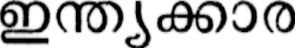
ഇന്ത്യക്കാര
